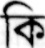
কি
